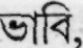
ভাবি,
